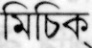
মিচিক্
